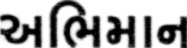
અભિમાન
